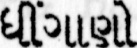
ધીંગાણો
